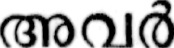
അവര്‍
